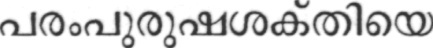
പരംപുരുഷശക്തിയെ
